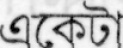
একেটা
